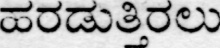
ಹರಡುತ್ತಿರಲು
